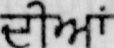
ਦੀਆਂ
